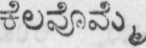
ಕೆಲವೊಮ್ಮೆ
